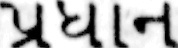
પ્રધાન
